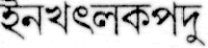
ইনখৎলকপদু
